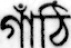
গাঁঠি
